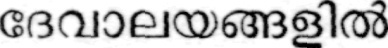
ദേവാലയങ്ങളില്‍
